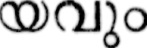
യവും
